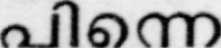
പിന്നെ
